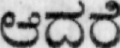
ಆದರೆ
